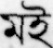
মই
